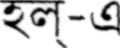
হল্-এ
